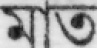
মাত
